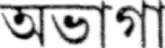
অভাগা
